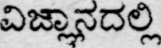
ವಿಜ್ಞಾನದಲ್ಲಿ
